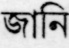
জানি
